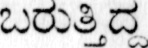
ಬರುತ್ತಿದ್ದ
